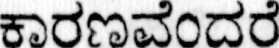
ಕಾರಣವೆಂದರೆ
